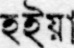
হইয়া
